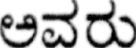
ಅವರು
